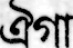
ঐগা
